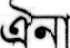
ঐনা
